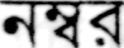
নম্বর
